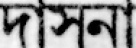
দাসনা
